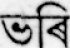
ভৰি
